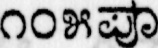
೧೦೫ಪೂ
